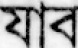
যাব
